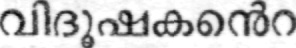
വിദൂഷകന്റെ
